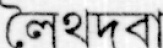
লৈথদবা
